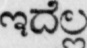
ಇದೆಲ್ಲ
